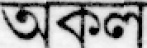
অকল
